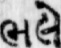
ભલે
